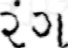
રંગ
